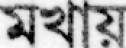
মখায়
